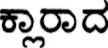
ಕ್ಲಾರಾದ
